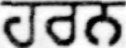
ਹਰਨ
